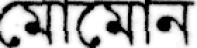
মোমোন
